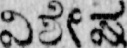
ವಿಶೇಷ
